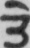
ਤੇ
